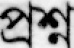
প্রশ্ন
